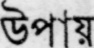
উপায়
